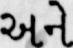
અને
